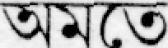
অমতে
